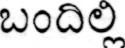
ಬಂದಿಲ್ಲಿ
